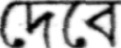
দেবে
